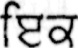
ਇਕ
